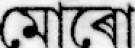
মোৰো
